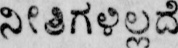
ನೀತಿಗಳಿಲ್ಲದೆ
